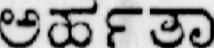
ಅರ್ಹತಾ
